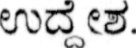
ಉದ್ದೇಶ.
